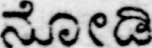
ನೋಡಿ
